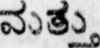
ಮತ್ತು
